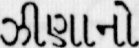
ઝીણાનો
